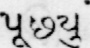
પૂછ્યું
